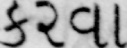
કરવા
